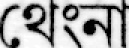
থেংনা
